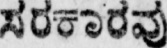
ಸರಕಾರವು
